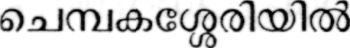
ചെമ്പകശ്ശേരിയില്‍
